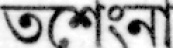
তশেংনা
